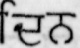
ਦਿਨ
